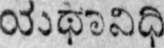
ಯಥಾವಿಧಿ
